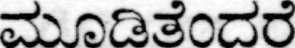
ಮೂಡಿತೆಂದರೆ
